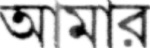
আমার
